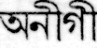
অনীগী
